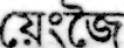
য়েংজৈ
